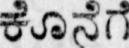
ಕೊನೆಗೆ
